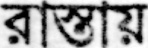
রাস্তায়
